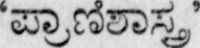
‘ಪ್ರಾಣಿಶಾಸ್ತ್ರ’
